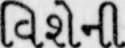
વિશેની
